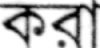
করা
